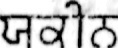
ਯਕੀਨ
